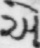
એ
